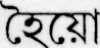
হৈয়ো
